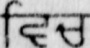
ਵਿਚ
